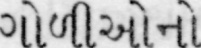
ગોળીઓનો
